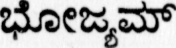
ಭೋಜ್ಯಮ್
